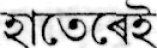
হাতেৰেই
